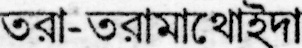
তরা-তরামাথোইদা
